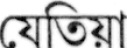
যেতিয়া
